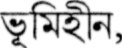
ভূমিহীন,
